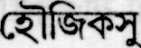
হৌজিকসু
